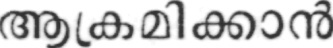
ആക്രമിക്കാന്‍
